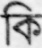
কি
